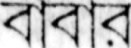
বাবার
